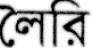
লৈরি
